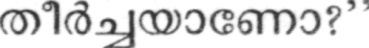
തീര്‍ച്ചയാണോ?"
